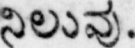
ನಿಲುವು.
